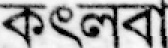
কৎলবা
